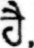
ਹੈ,
